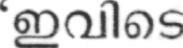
‘ഇവിടെ
